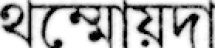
থম্মোয়দা
